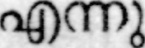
എന്നു
